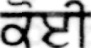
ਕੋਈ
